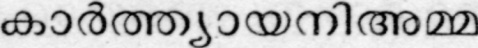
കാര്‍ത്ത്യായനിഅമ്മ
